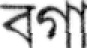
বগা
